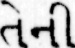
તેની
